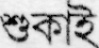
শুকাই
